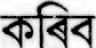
কৰিব
